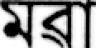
মৱা
